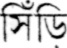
সিঁড়ি
